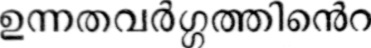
ഉന്നതവര്‍ഗ്ഗത്തിന്റെ
